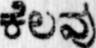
ಕೆಲವು
